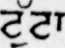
ਟੁੱਟਾ
